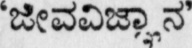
‘ಜೀವವಿಜ್ಞಾನ’
